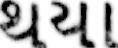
થયા
